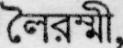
লৈরম্মী,
